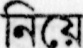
নিয়ে
